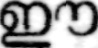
ഈ
